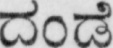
ದಂಡೆ
